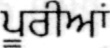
ਪੂਰੀਆਂ
